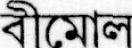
বীমোল
